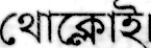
থোক্লোই।
